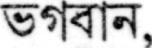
ভগবান,
